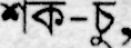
শক-চু,
